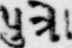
પુત્રો
